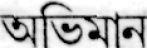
অভিমান
